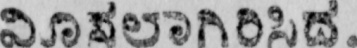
ಮೀಸಲಾಗಿರಿಸಿದ.
